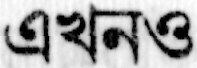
এখনও
